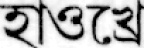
হাওখ্রে
